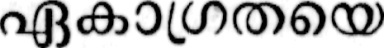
ഏകാഗ്രതയെ
